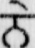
ਨੇ
